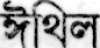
ঈথিল
